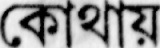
কোথায়
